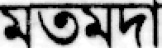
মতমদা
